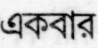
একবার
